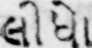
લીધો
